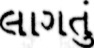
લાગતું
